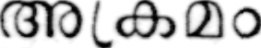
അക്രമം
